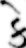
કે
